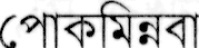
পোকমিন্নবা
